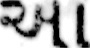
આ
